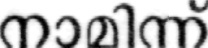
നാമിന്ന്
